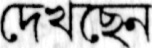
দেখছেন
